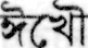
ঈখৌ
